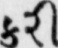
કરી
